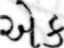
એક
